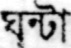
ঘন্টা
